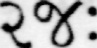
રજઃ
